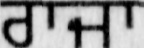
ਰਾਜਾ
